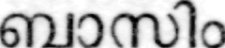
ബാസിം
